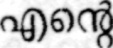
എന്റെ
